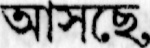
আসছে,
